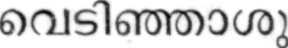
വെടിഞ്ഞാശു
